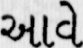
આવે
